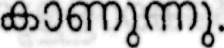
കാണുന്നു.
